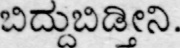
ಬಿದ್ದುಬಿಡ್ತೀನಿ.
